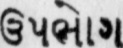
ઉપભોગ
